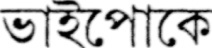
ভাইপোকে
